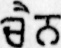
ਚੈਨ
